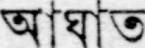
আঘাত
